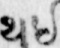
થઈ
